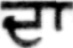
ਦਾ
